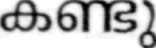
കണ്ടു
